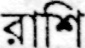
রাশি
